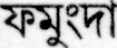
ফমুংদা
